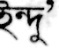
ইন্দু’
